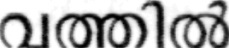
വത്തില്‍
